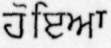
ਹੋਇਆ
